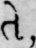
તે,
